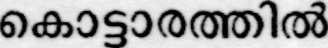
കൊട്ടാരത്തില്‍
